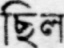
ছিল
